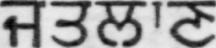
ਜਤਲਾਣ
